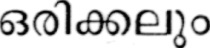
ഒരിക്കലും
